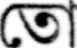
তো
